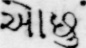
ઓછું
